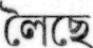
লৈছে
